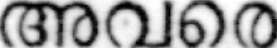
അവരെ
